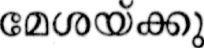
മേശയ്ക്കു
